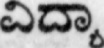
ವಿದ್ಯಾ
